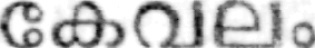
കേവലം
